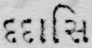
દદાસિ
